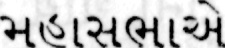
મહાસભાએ
